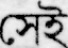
সেই
